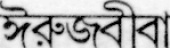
ঈরুজবীবা
